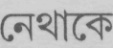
নেথাকে
